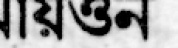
মায়ওন
